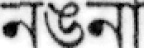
নঙনা
